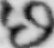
છ
